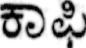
ಕಾಫಿ
